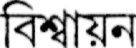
বিশ্বায়ন
